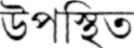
উপস্থিত
